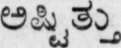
ಅಷ್ಟಿತ್ತು
